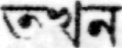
তখন
